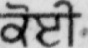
ਕੋਈ
